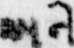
અને
